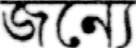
জন্যে
